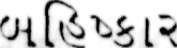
બહિષ્કાર
